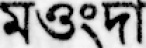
মওংদা
